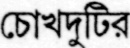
চোখদুটির
